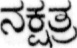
ನಕ್ಷತ್ರ
